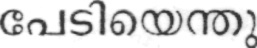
പേടിയെന്തു
